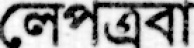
লেপত্রবা
